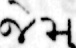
જેમ
